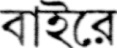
বাইরে
